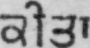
ਕੀਤਾ
